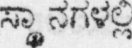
ಸ್ಥಾನಗಳಲ್ಲಿ
